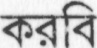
করবি
